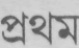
প্ৰথম
